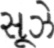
સૂઝે
